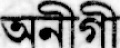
অনীগী
